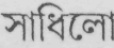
সাধিলো
